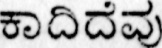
ಕಾದಿದೆವು
